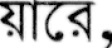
য়ারে,
